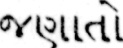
જણાતો
